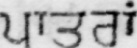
ਪਾਤਰਾਂ
